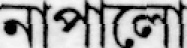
নাপালো
